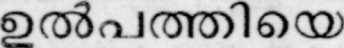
ഉല്‍പത്തിയെ
